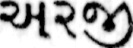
અરજી
